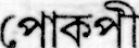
পোকপী
